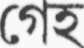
গেহ
